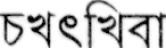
চখৎখিবা
